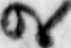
જ
